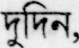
দুদিন,
